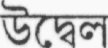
উদ্বেল
